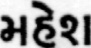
મહેશ
